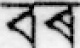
বৰ
